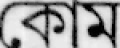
কোম
